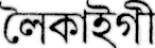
লৈকাইগী
